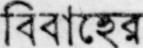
বিবাহের
